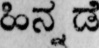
ಹಿನ್ನಡೆ
